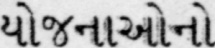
યોજનાઓનો
